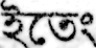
ইতেং
